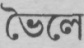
ভৈলে
